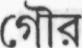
গৌর
